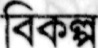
বিকল্প
